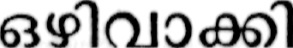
ഒഴിവാക്കി
